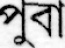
পুবা
